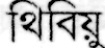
থিবিয়ু
